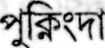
পুক্নিংদা
